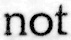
not
